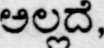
ಅಲ್ಲದೆ,
